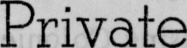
Private
